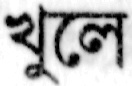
খুলে
